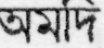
অমদি
